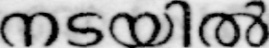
നടയില്‍
